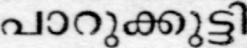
പാറുക്കുട്ടി
